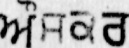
ਔਸਕਰ
